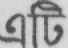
এটি
